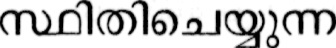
സ്ഥിതിചെയ്യുന്ന
